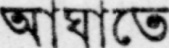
আঘাতে
